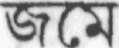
জমে
